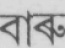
বাৰু
